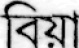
বিয়া
